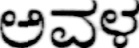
ಅವಳ
